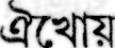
ঐখোয়
